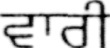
ਵਾਰੀ
